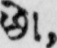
છો,
